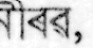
নীৰৱ,
